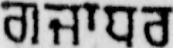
ਗਜਾਧਰ
